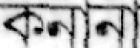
কনানা
